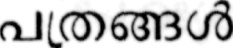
പത്രങ്ങള്‍
